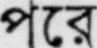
পরে
